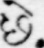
છે.
